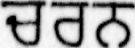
ਚਰਨ
